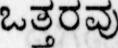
ಒತ್ತರವು
